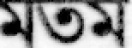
মতম
